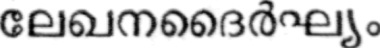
ലേഖനദൈര്‍ഘ്യം
